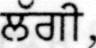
ਲੱਗੀ,
